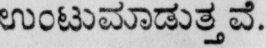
ಉಂಟುಮಾಡುತ್ತವೆ.
